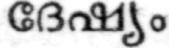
ദേഷ്യം
